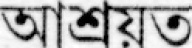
আশ্রয়ত
